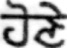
ਹੋਣੇ
